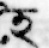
হৈ
